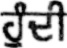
ਹੁੰਦੀ
